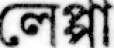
লেপ্পা
